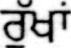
ਰੁੱਖਾਂ
